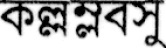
কল্লম্লবসু
